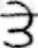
ਤੇ
